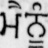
ਮੈਨੂੰ
